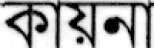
কায়না
